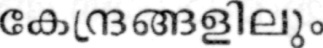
കേന്ദ്രങ്ങളിലും
